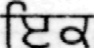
ਇਕ
